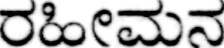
ರಹೀಮನ
